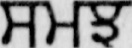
ਸਮਝ
